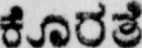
ಕೊರತೆ
